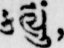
કહ્યું,
